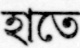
হাতে
